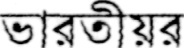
ভারতীয়র
